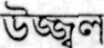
উজ্জ্বল
